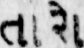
તારો
